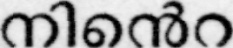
നിന്റെ
